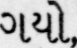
ગયો,
